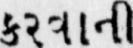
કરવાની
